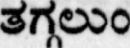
ತಗ್ಗಲುಂ
